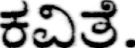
ಕವಿತೆ.
